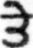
ਤੇ
